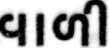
વાળી
